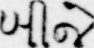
બીજે
